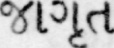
જાગૃત
